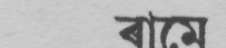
ৰামে
